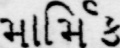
માર્મિક
